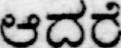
ಆದರೆ
